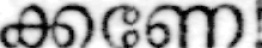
ക്കണേ!
